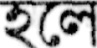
হলে
